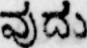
ವುದು
